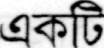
একটি
